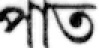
পাত
